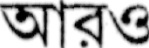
আরও
